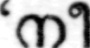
‘നീ
